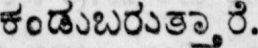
ಕಂಡುಬರುತ್ತಾರೆ.
